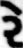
રે
